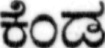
ಕೆಂಡ
